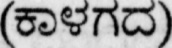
(ಕಾಳಗದ)
